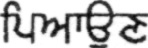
ਪਿਆਉਣ
